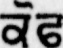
ਕੋਫ
